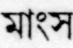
মাংস
